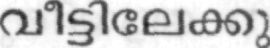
വീട്ടിലേക്കു
